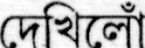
দেখিলোঁ
